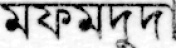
মফমদুদা
